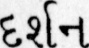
દર્શન
